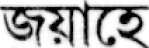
জয়াহে
